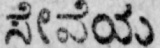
ಸೇವೆಯ
